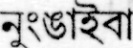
নুংঙাইবা
